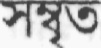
সম্বৃত
